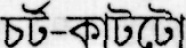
চৰ্ট-কাটটো
